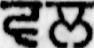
ਵਲ
